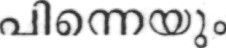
പിന്നെയും
